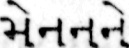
મેનનને
